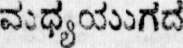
ಮಧ್ಯಯುಗದ
